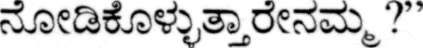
ನೋಡಿಕೊಳ್ಳುತ್ತಾರೇನಮ್ಮ?"
